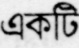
একটি
